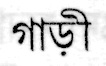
গাড়ী
